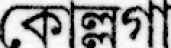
কোল্লগা
